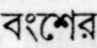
বংশের
